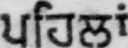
ਪਹਿਲਾਂ
